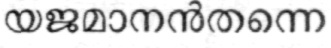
യജമാനന്‍തന്നെ
